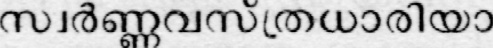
സ്വര്‍ണ്ണവസ്ത്രധാരിയാ
